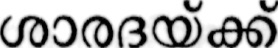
ശാരദയ്ക്ക്
